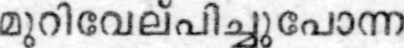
മുറിവേല്പിച്ചുപോന്ന
